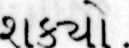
શક્યો.
